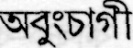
অবুংচাগী
